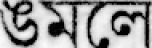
ঙমলে
